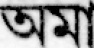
অমা
